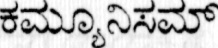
ಕಮ್ಯೂನಿಸಮ್
